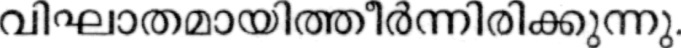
വിഘാതമായിത്തീര്‍ന്നിരിക്കുന്നു.
